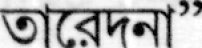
তারেদনা”
